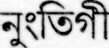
নুংতিগী
